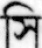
সি
